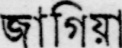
জাগিয়া
